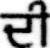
ਦੀ
